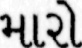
મારો
